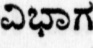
ವಿಭಾಗ
